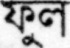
ফুল
